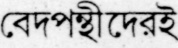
বেদপন্থীদেরই
